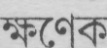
ক্ষণেক
